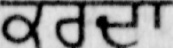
ਕਰਦਾ
